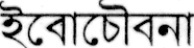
ইবোচৌনা
